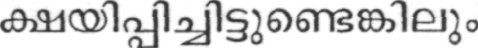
ക്ഷയിപ്പിച്ചിട്ടുണ്ടെങ്കിലും
